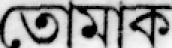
তোমাক
